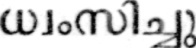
ധ്വംസിച്ചു
